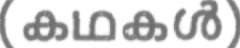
(കഥകള്‍)
